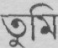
তুমি
